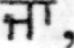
ਜਾ,
